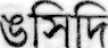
ঙসিদি
